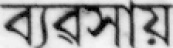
ব্যৱসায়
